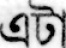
এটা
